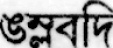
ঙম্লবদি
